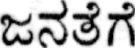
ಜನತೆಗೆ
